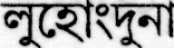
লুহোংদুনা
